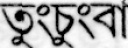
তুংচুংবা
